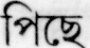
পিছে
